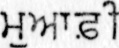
ਮੁਆਫ਼ੀ
